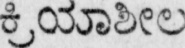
ಕ್ರಿಯಾಶೀಲ
